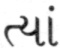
ત્યાં
